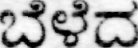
ಬೆಳೆದ
